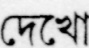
দেখো
